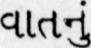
વાતનું
